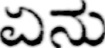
ಏನು
